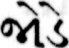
જોડે
